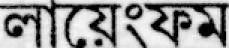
লায়েংফম
